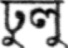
ঢুলু
